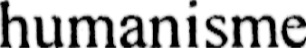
humanisme
